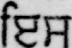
ਇਸ
